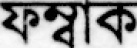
ফম্বাক
